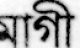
মাগী
